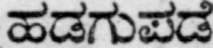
ಹಡಗುಪಡೆ
